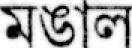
মঙাল
